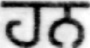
ਹਨ
